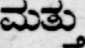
ಮತ್ತು
